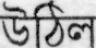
উঠিল
